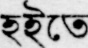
হইতে
